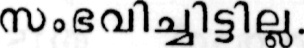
സംഭവിച്ചിട്ടില്ല.
